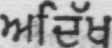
ਅਦਿੱਖ
